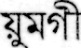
য়ুমগী
